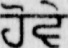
ਹੋਵੇ
